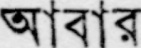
আবার
